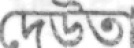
দেউতা
